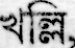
খল্লি,
